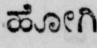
ಹೋಗಿ
